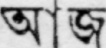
আজ
